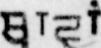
ਥਾਵਾਂ
